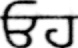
ਓਹ
